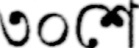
৩০শে
